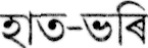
হাত-ভৰি
